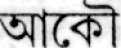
আকৌ
